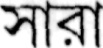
সারা
